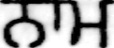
ਨਾਮ
